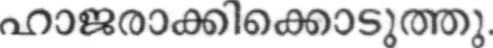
ഹാജരാക്കിക്കൊടുത്തു.
